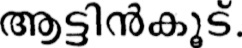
ആട്ടിന്‍കൂട്.
